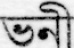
ভনী
